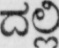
ದಲ್ಲಿ
